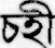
চহী
